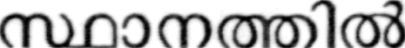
സ്ഥാനത്തില്‍
